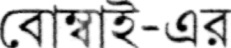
বোম্বাই-এর
